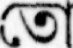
তো
